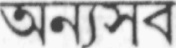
অন্যসব
